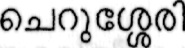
ചെറുശ്ശേരി
